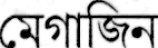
মেগাজিন
